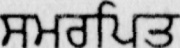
ਸਮਰਪਿਤ
